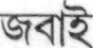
জবাই
